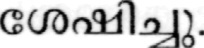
ശേഷിച്ചു.
